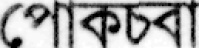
পোকচবা
